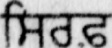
ਸਿਰਫ਼
